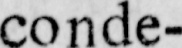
conde-
